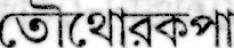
তৌথোরকপা
